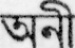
অনী
